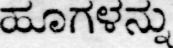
ಹೂಗಳನ್ನು
